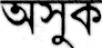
অসুক
